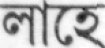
লাহে
